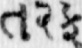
તરફ
